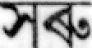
সৰু
